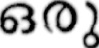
ഒരു
